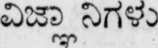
ವಿಜ್ಞಾನಿಗಳು
